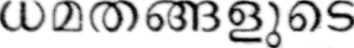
ധമതങ്ങളുടെ
